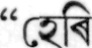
"হেৰি
